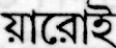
য়ারোই
